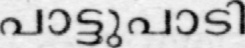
പാട്ടുപാടി
